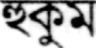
হুকুম
